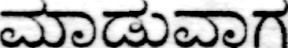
ಮಾಡುವಾಗ
